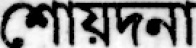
শোয়দনা
